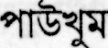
পাউখুম
